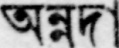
অন্নদা
